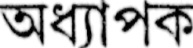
অধ্যাপক
